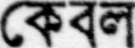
কেবল
